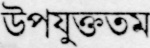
উপযুক্ততম
